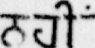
ਨਹੀਂ
